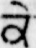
ਕੇ
